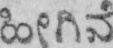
ಹೀಗಿವೆ
